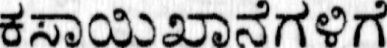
ಕಸಾಯಿಖಾನೆಗಳಿಗೆ
